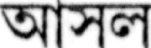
আসল
